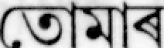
তোমাৰ
